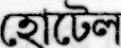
হোটেল
